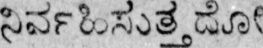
ನಿರ್ವಹಿಸುತ್ತದೋ
